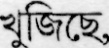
খুজিছে,
